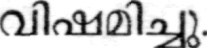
വിഷമിച്ചു.
